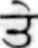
ਤੇ
